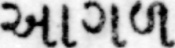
આગળ
